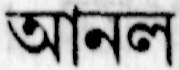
আনল
